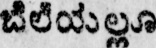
ಬೆಲೆಯಲ್ಲೂ
